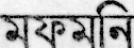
মফমনি
